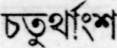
চতুর্থাংশ
